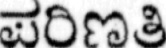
ಪರಿಣತಿ
